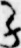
કે
